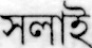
সলাই
